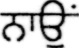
ਨਾਉਂ
